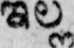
ಇಲ್ಲ
